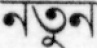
নতুন
